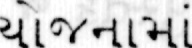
યોજનામાં
